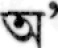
অ'
